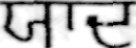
ਯਾਦ
